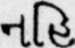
નહિ
